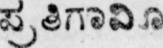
ಪ್ರತಿಗಾಮೀ
